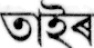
তাইৰ
